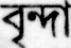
বৃন্দা
